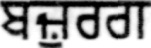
ਬਜ਼ੁਰਗ
